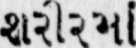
શરીરમાં
